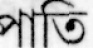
পাতি
